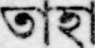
তাহা
